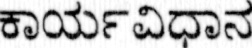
ಕಾರ್ಯವಿಧಾನ
